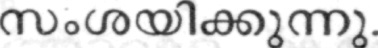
സംശയിക്കുന്നു.
